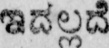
ಇದಲ್ಲದೆ
